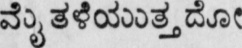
ಮೈತಳೆಯುತ್ತದೋ
